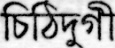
চিঠিদুগী
